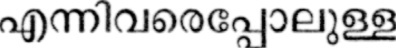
എന്നിവരെപ്പോലുള്ള
